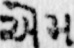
એમ
